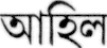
আহিল
